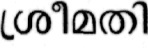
ശ്രീമതി
